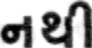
નથી
